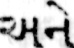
અને
